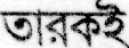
তারকই
